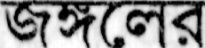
জঙ্গলের
